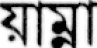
য়াম্না
